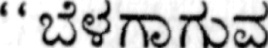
"ಬೆಳಗಾಗುವ
